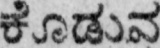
ಕೊಡುವ
